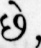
છે,
